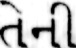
તેની
